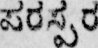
ಪರಸ್ಪರ
